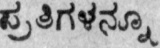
ಪ್ರತಿಗಳನ್ನೂ
